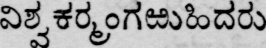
ವಿಶ್ವಕರ್ಮಂಗಱುಹಿದರು
